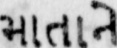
માતાને
